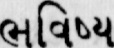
ભવિષ્ય
